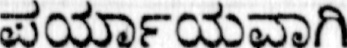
ಪರ್ಯಾಯವಾಗಿ
